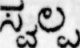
ಸ್ವಲ್ಪ
